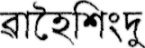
ৱাহৈশিংদু
